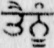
ਤੈਨੂੰ
